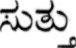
ಸುತ್ತು
